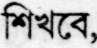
শিখবে,
